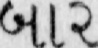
બાર
